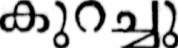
കുറച്ചു
